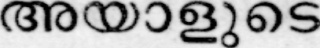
അയാളുടെ
